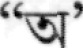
"অ'
